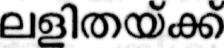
ലളിതയ്ക്ക്
